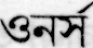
ওনর্স
